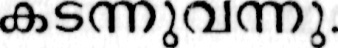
കടന്നുവന്നു.
